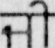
ਜੀ
